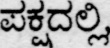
ಪಕ್ಷದಲ್ಲಿ,
